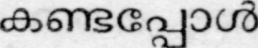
കണ്ടപ്പോള്‍
